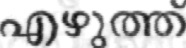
എഴുത്ത്
